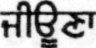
ਜੀਊਣਾ
